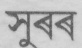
সুৰৰ
